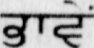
ਭਾਵੇਂ
